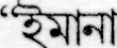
“ইমানা
